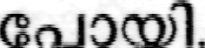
പോയി.
